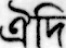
ঐদি
